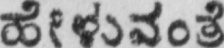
ಹೇಳುವಂತೆ
